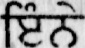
ਇੰਨੇ
